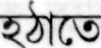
হঠাতে
